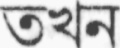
তখন
